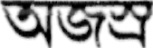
অজস্র
